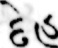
દેહ
